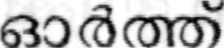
ഓര്‍ത്ത്
